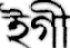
ইগী
